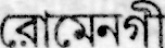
রোমেনগী
